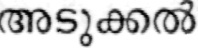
അടുക്കല്‍
